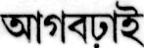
আগবঢ়াই
